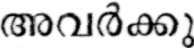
അവര്‍ക്കു
